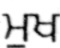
ਮੁਖ
